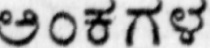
ಅಂಕಗಳ
